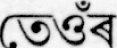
তেওঁৰ
